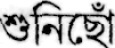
শুনিছোঁ
